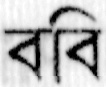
ববি
